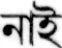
নাই
